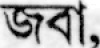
জবা,
